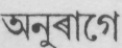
অনুৰাগে
